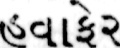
હવાફેર
